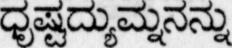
ಧೃಷ್ಟದ್ಯುಮ್ನನನ್ನು
